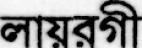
লায়রগী
